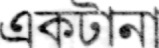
একটানা
